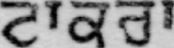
ਟਾਕਰਾ
